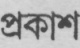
প্ৰকাশ
